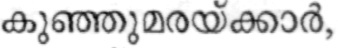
കുഞ്ഞുമരയ്ക്കാര്‍,
